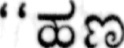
"ಹಣ
